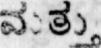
ಮತ್ತು
